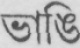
ভাঙি
